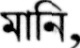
মানি
